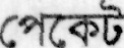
পেকেট
